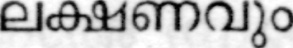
ലക്ഷണവും
